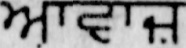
ਆਵਾਜ਼
